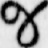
જ
